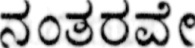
ನಂತರವೇ
